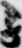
કે
